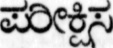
ಪರೀಕ್ಷಿಸ
